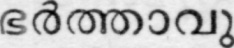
ഭര്‍ത്താവു
